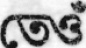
তেওঁ
